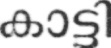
കാട്ടി
